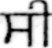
ਸੀ
